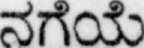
ನಗೆಯ
